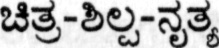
ಚಿತ್ರ-ಶಿಲ್ಪ-ನೃತ್ಯ
